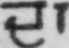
ਦਾ
